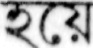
হয়ে
